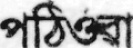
পঠিওৱা
